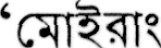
‘মোইরাং
